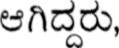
ಆಗಿದ್ದರು,
